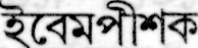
ইবেমপীশক
